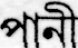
পানী
